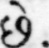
છે.
